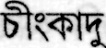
চীংকাদু
